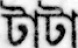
টাটা
